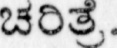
ಚರಿತ್ರೆ.
